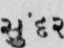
સુંદર
